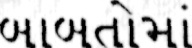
બાબતોમાં
